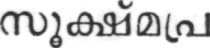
സൂക്ഷ്മപ്ര
